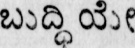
ಬುದ್ಧಿಯೇ
